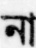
না
